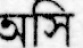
অসি
